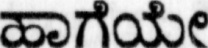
ಹಾಗೆಯೇ
